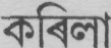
কৰিলা
